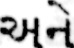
અને
